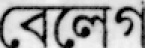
বেলেগ
